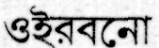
ওইরবনো
